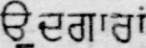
ਉਦਗਾਰਾਂ
